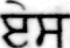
ਏਸ
